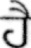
ਹੈ
